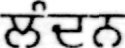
ਲੰਦਨ
